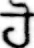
ਹੋ
